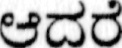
ಆದರೆ
